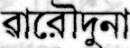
ৱারৌদুনা
